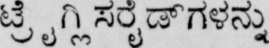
ಟ್ರೈಗ್ಲಿಸರೈಡ್‌ಗಳನ್ನು
